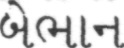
બેભાન
